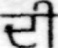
ਦੀ
